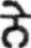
ਨੇ
